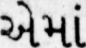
એમાં
